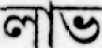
লাভ
